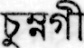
চুম্নগী
